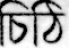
চিঠি
